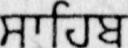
ਸਾਹਿਬ
